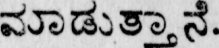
ಮಾಡುತ್ತಾನೆ.
